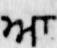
ਆ
